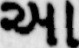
આ
